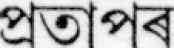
প্রতাপৰ
